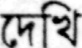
দেখি
